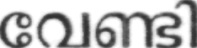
വേണ്ടി
